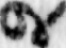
જ
